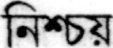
নিশ্চয়
